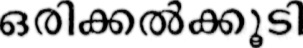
ഒരിക്കല്‍ക്കൂടി
